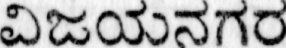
ವಿಜಯನಗರ
